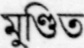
মুণ্ডিত
